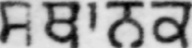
ਸਥਾਨਕ
